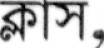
ক্লাস,
